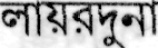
লায়রদুনা
